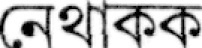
নেথাকক
